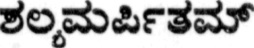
ಶಲ್ಯಮರ್ಪಿತಮ್
